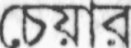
চেয়ার
